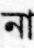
না
